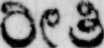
ರೀತಿ
